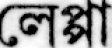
লেপ্পা
